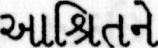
આશ્રિતને
